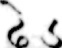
ઢેડ
